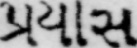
પ્રયાસ
